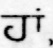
ਹਾਂ,
